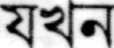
যখন
